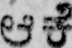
ಆಕೆ
